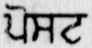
ਪੋਸਟ
